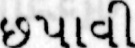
છપાવી
